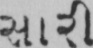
સારી
